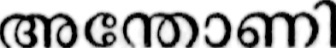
അന്തോണി
